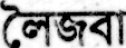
লৈজবা
